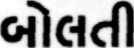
બોલતી
